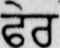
ਫੇਰ
